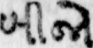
બીજો
